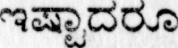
ಇಷ್ಟಾದರೂ
